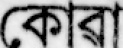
কোৱা
